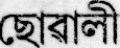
ছোৱালী
